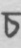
চ
